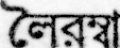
লৈরম্বা
